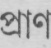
প্ৰাণ
